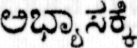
ಅಭ್ಯಾಸಕ್ಕೆ
